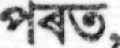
পৰত,
